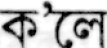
ক'লে
